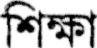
শিক্ষা
